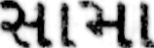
સામા
